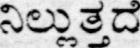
ನಿಲ್ಲುತ್ತದೆ
